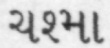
ચશ્મા
